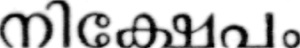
നിക്ഷേപം
